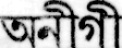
অনীগী
